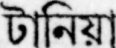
টানিয়া
